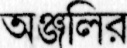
অঞ্জলির
